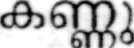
കണ്ണു
